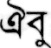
ঐবু
